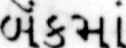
બેંકમાં
